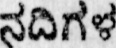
ನದಿಗಳ
